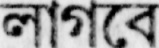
লাগবে
